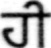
ਹੀ
